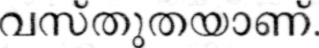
വസ്തുതയാണ്.
